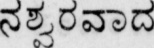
ನಶ್ವರವಾದ
